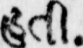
હતી.
